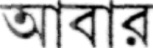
আবার
